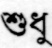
শুধু
